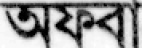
অফবা
